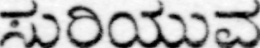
ಸುರಿಯುವ
